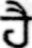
ਹੈ
